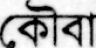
কৌবা
